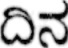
ದಿನ
